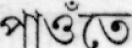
পাওঁতে
